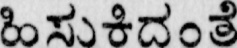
ಹಿಸುಕಿದಂತೆ
